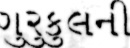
ગુરુકુલની
